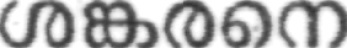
ശങ്കരനെ
